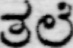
ತಲೆ
